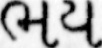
ભય
